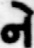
ને
